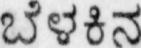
ಬೆಳಕಿನ
